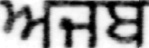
ਅਜਬ
